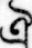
ঐ
